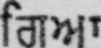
ਗਿਆ
